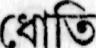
ধোতি
